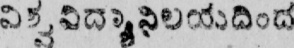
ವಿಶ್ವವಿದ್ಯಾನಿಲಯದಿಂದ
